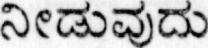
ನೀಡುವುದು
